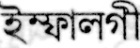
ইম্ফালগী
